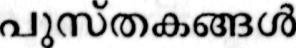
പുസ്തകങ്ങള്‍
